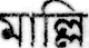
মাল্লি
